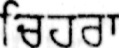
ਚਿਹਰਾ
